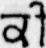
ਕੀ
